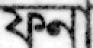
ফনা
